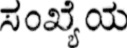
ಸಂಖ್ಯೆಯ
